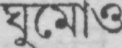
ঘুমোও
